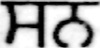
ਸਨ
